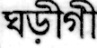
ঘড়ীগী
